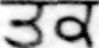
ਤਕ
